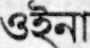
ওইনা
